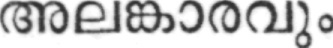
അലങ്കാരവും
